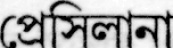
প্রেসিলানা
